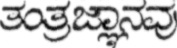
ತಂತ್ರಜ್ಞಾನವು
